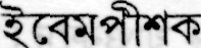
ইবেমপীশক
